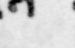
અને
